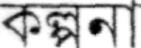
কল্পনা
